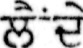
ਲੈਂਦੇ
